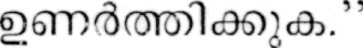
ഉണര്‍ത്തിക്കുക."
